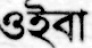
ওইবা
